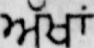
ਅੱਖਾਂ
